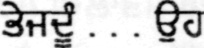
ਭੇਜਦੂੰ...ਉਹ
